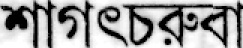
শাগৎচরুবা
